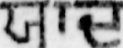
ਯਾਦ
